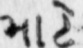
માટે
